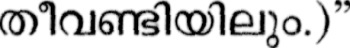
തീവണ്ടിയിലും.)”
